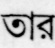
তার
